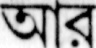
আর
